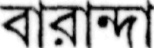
বারান্দা
